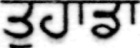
ਤੁਹਾਡਾ
